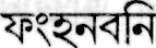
ফংহনবনি
